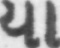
યા
